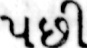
પછી
